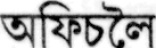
অফিচলৈ
